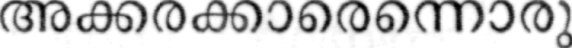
അക്കരക്കാരെന്നൊരു
